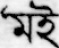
'মই
